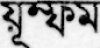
য়ূম্ফম
